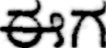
ಈಗ
